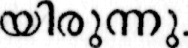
യിരുന്നു.
